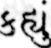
કહ્યું
